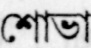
শোভা
